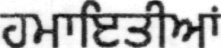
ਹਮਾਇਤੀਆਂ
